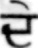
ਦੇ
